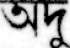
অদু
